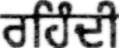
ਰਹਿੰਦੀ
